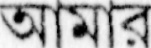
আমার
